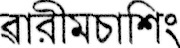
ৱারীমচাশিং
